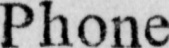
Phone
